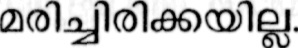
മരിച്ചിരിക്കയില്ല.
